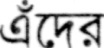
এঁদের
